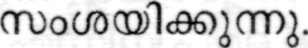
സംശയിക്കുന്നു.
